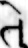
તે
